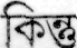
কিন্তু
